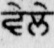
ਵੇਲੇ
